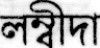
লম্বীদা
